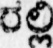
ರಲ್ಲಿ
